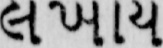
લખાય
